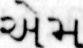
એમ
